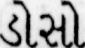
ડોસો
